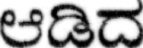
ಆಡಿದ
